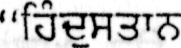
''ਹਿੰਦੁਸਤਾਨ
